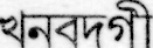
খনবদগী
